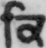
ਕਿ
